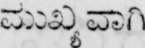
ಮುಖ್ಯವಾಗಿ
